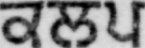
ਕਲਪ
